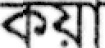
কয়া
